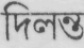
দিলন্ত
